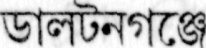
ডালটনগঞ্জে
